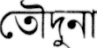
তৌদুনা
